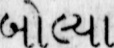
બોલ્યા
